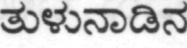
ತುಳುನಾಡಿನ
